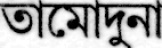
তামোদুনা
